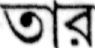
তার
